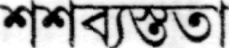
শশব্যস্ততা
